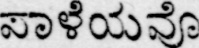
ಪಾಳೆಯವೊ
